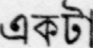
একটা
